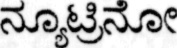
ನ್ಯೂಟ್ರಿನೋ
